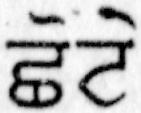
ਛੋਟੇ
